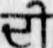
ਦੀ
